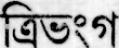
ত্রিভংগ
